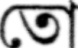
তো
